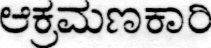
ಆಕ್ರಮಣಕಾರಿ
